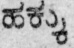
ಹಕ್ಕು
